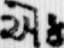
એક
